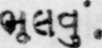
ભૂલવું.
